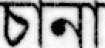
চানা
